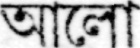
আলো
